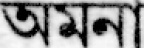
অমনা
